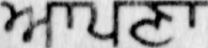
ਆਪਣਾ
